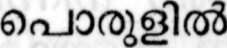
പൊരുളില്‍
